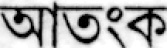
আতংক
